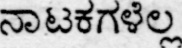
ನಾಟಕಗಳೆಲ್ಲವೂ
